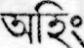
অহিং
